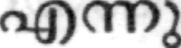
എന്നു
